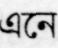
এনে
